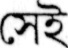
সেই
